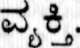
ವ್ಯಕ್ತಿ.
